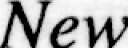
New
